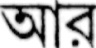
আর
